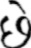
છે
